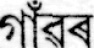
গাঁৱৰ
